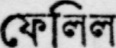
ফেলিল
